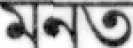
মনত
